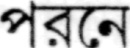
পরনে
